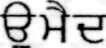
ਉਮੈਦ
